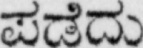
ಪಡೆದು
